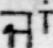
ਜਾਂ
